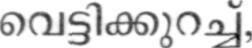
വെട്ടിക്കുറച്ച്,
